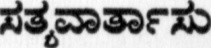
ಸತ್ಯವಾರ್ತಾಸು
